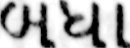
બધા
